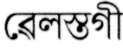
ৱেলস্তগী
